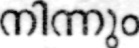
നിന്നും
